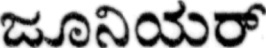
ಜೂನಿಯರ್
